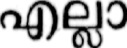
എല്ലാ
